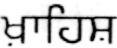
ਖ਼ਾਹਿਸ਼
